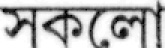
সকলো
